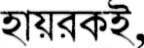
হায়রকই,
